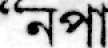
“নপা
